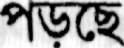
পড়ছে
